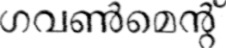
ഗവണ്‍മെന്റ്
